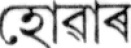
হোৱাৰ
